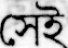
সেই
